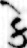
કે
